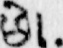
છો.
